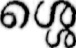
ശ്ശെ
